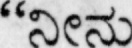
“ನೀನು
